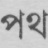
পথ
